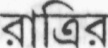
রাত্রির
